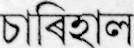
চাৰিহাল
